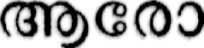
ആരോ
